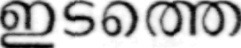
ഇടത്തെ
